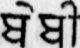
ਬੇਬੀ
